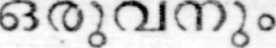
ഒരുവനും
